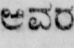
ಅವರ
